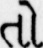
તો
